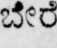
ಬೇರೆ
